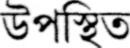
উপস্থিত
